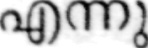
എന്നു
